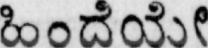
ಹಿಂದೆಯೇ
